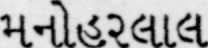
મનોહરલાલ
